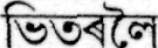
ভিতৰলৈ
